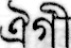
ঐগী
